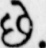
છે.
